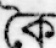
কৈ
